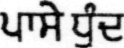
ਪਾਸੇਧੁੰਦ
